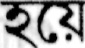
হয়ে
